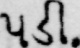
પડી.
